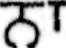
ਨਾ
